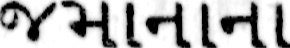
જમાનાના
